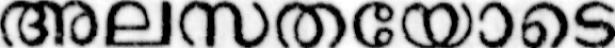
അലസതയോടെ
